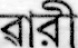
ৱারী
